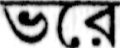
ভরে
